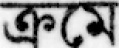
ক্রমে
